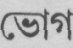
ভোগ
